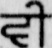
ਵੀ
